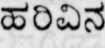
ಹರಿವಿನ
